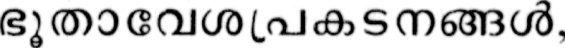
ഭൂതാവേശപ്രകടനങ്ങള്‍,
